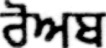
ਰੋਅਬ
